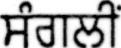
ਸੰਗਲੀਂ
